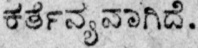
ಕರ್ತವ್ಯವಾಗಿದೆ.
